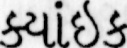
ક્યાંઈક
